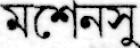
মশেনসু
